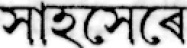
সাহসেৰে
